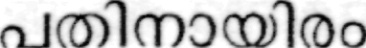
പതിനായിരം
